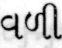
વળી
